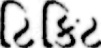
ટિકિટ
